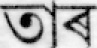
তাৰ
